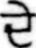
ਦੇ
